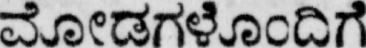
ಮೋಡಗಳೊಂದಿಗೆ
